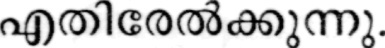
എതിരേല്‍ക്കുന്നു.
